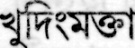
খুদিংমক্তা
